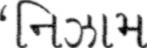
'નિઝામ
